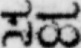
ಸಹ
